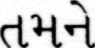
તમને
